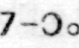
7-ാം
